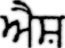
ਐਸ਼
